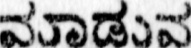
ಮಾಡುವ
